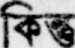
কিন্তু
